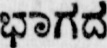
ಭಾಗದ
